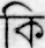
কি
